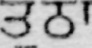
ਤੁਠਾ
